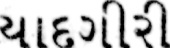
યાદગીરી
